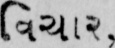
વિચાર,
